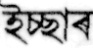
ইচ্ছাৰ
